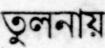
তুলনায়
